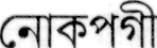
নোকপগী
